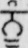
ਨੂੰ
